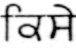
ਕਿਸੇ
